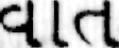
વાત
